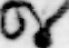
જ
